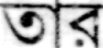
তার
